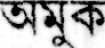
অমুক
